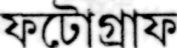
ফটোগ্রাফ
